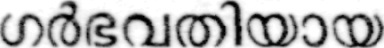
ഗര്‍ഭവതിയായ
